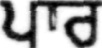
ਪਾਰ
